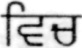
ਵਿਚ
